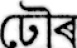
টৌৰ
